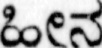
ಹೀನ
